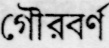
গৌরবর্ণ
